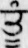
ਤੂੰ
